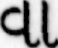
વા
